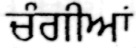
ਚੰਗੀਆਂ
